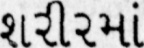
શરીરમાં
